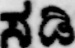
ಸಡಿ
